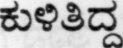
ಕುಳಿತಿದ್ದ
